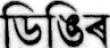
ডিঙিৰ
